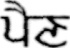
ਪੈਣ
